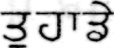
ਤੁਹਾਡੇ
